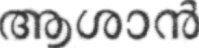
ആശാന്‍
